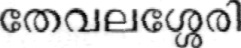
തേവലശ്ശേരി
